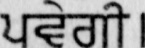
ਪਵੇਗੀ।
